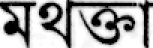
মথক্তা
